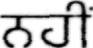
ਨਹੀਂ
